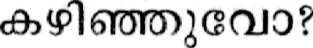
കഴിഞ്ഞുവോ?
